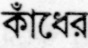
কাঁধের
